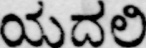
ಯದಲಿ
